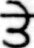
ਤੇ
